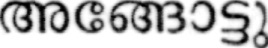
അങ്ങോട്ടു
